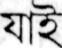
যাই
